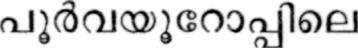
പൂര്‍വയൂറോപ്പിലെ
